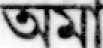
অমা
